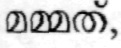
മമ്മത്,
